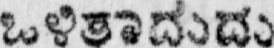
ಒಳಿತಾದುದು
